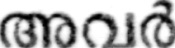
അവര്‍
